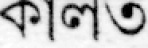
কালত
